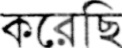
করেছি
